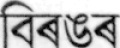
বিৰঙৰ
